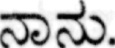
ನಾನು.
